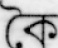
কৈ
